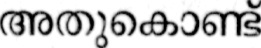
അതുകൊണ്ട്
